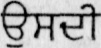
ਉਸਦੀ
